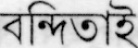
বন্দিতাই
